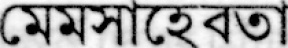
মেমসাহেবতা
